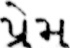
પ્રેમ
